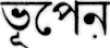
ভূপেন
